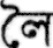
লৈ
